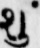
શું
